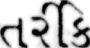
તરીકે
